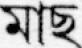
মাছ
